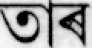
তাৰ
